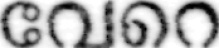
വേറെ
